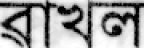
ৱাখল
